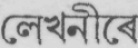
লেখনীৰে
